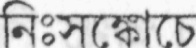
নিঃসঙ্কোচে
